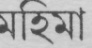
মহিমা
